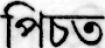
পিচত
